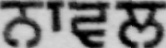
ਨਾਵਲ
